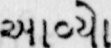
આવ્યો
